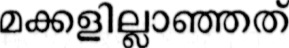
മക്കളില്ലാഞ്ഞത്
